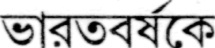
ভারতবর্ষকে
